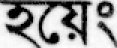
হয়েং
